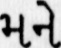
મને
